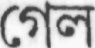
গেল
